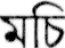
মচি
